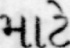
માટે
